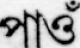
পাওঁ
